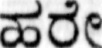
ಹರೇ
